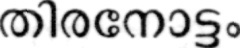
തിരനോട്ടം
